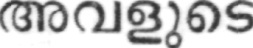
അവളുടെ
